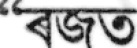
"ৰজত
